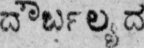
ದೌರ್ಬಲ್ಯದ
